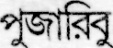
পুজারিবু
